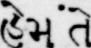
હેમતે
